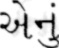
એનું
